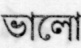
ভালো
